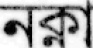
নক্না
